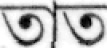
তাত
